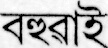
বহুৱাই
